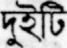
দুইটি
